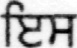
ਇਸ
